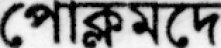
পোক্লমদে
